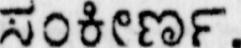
ಸಂಕೀರ್ಣ.
